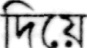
দিয়ে
